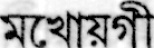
মখোয়গী
